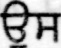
ਉਸ
